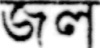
জল
